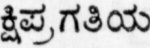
ಕ್ಷೀಪ್ರಪ್ರಗತಿಯ
